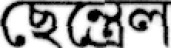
ছেন্ত্রেল
